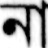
না
